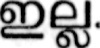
ഇല്ല.
